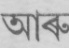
আৰু
